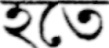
হতে
